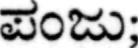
ಪಂಜು;
